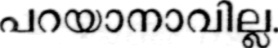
പറയാനാവില്ല.
